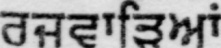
ਰਜਵਾੜਿਆਂ
